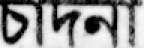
চাদনা
